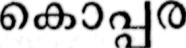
കൊപ്പര
